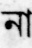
না
